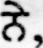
ਨੇ,
